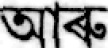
আৰু
